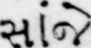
સાંજે
